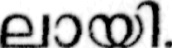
ലായി.
